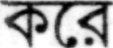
করে
